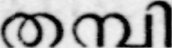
തമ്പി
